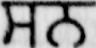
ਸਨ
